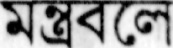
মন্ত্রবলে
